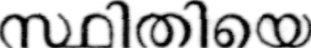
സ്ഥിതിയെ
